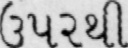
ઉપરથી
